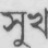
সুখ
